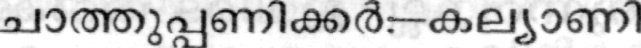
ചാത്തുപ്പണിക്കര്‍:-കല്യാണി
